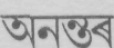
অনন্তৰ
